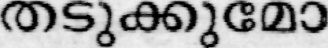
തടുക്കുമോ
